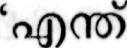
‘എന്ത്
